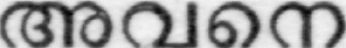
അവനെ
